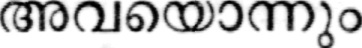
അവയൊന്നും
